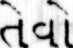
તેવો
